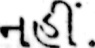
નહીં.
